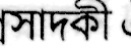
প্রসাদকী
